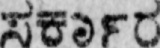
ಸರ್ಕಾರ
